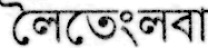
লৈতেংলবা
